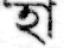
“হা
